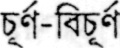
চূর্ণ-বিচূর্ণ
